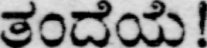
ತಂದೆಯೆ!
